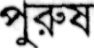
পুরুষ
